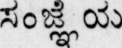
ಸಂಜ್ಞೆಯ
